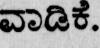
ವಾಡಿಕೆ.
